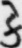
કે
